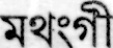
মথংগী
